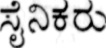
ಸೈನಿಕರು
